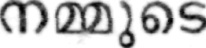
നമ്മുടെ
